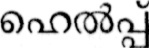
ഹെല്‍പ്പ്
